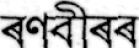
ৰণবীৰৰ
